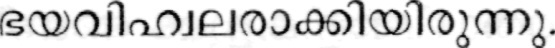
ഭയവിഹ്വലരാക്കിയിരുന്നു.
